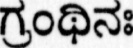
ಗ್ರಂಥಿನಃ
